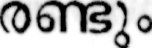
രണ്ടും
